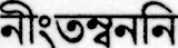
নীংতম্বননি
